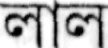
লাল
